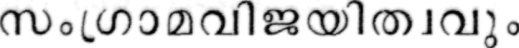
സംഗ്രാമവിജയിത്വവും
